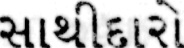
સાથીદારો
